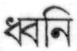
ধ্বনি
